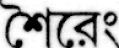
শৈরেং
